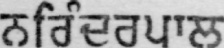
ਨਰਿੰਦਰਪਾਲ
